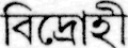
বিদ্ৰোহী
